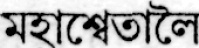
মহাশ্বেতালৈ
